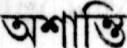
অশান্তি
